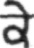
ਕੇ
